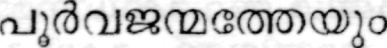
പൂര്‍വജന്മത്തേയും
